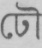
ঢৌ
